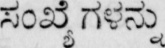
ಸಂಖ್ಯೆಗಳನ್ನು
